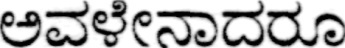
ಅವಳೇನಾದರೂ
